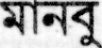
মানবু
